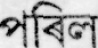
পৰিল
